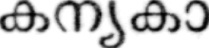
കന്യകാ
